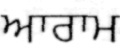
ਆਰਾਮ
